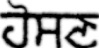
ਹੋਸਣ
